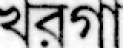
খরগা
